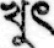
খুৎ
